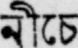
নীচে
